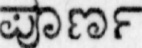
ಪೂರ್ಣ
